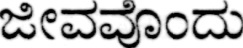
ಜೀವವೊಂದು
